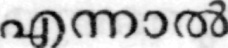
എന്നാല്‍
